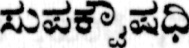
ಸುಪಕ್ವೌಷಧಿ
